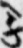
કે
